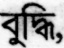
বুদ্ধি,
